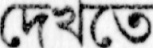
দেখতে
